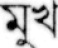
মুখ
